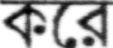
করে
